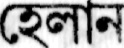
হেলান
